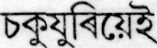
চকুযুৰিয়েই
